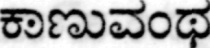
ಕಾಣುವಂಥ
